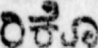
ರಿಕೊ
